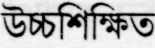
উচ্চশিক্ষিত
